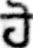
ਹੋ
